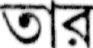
তার
